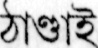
ঠাণ্ডাই
